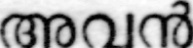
അവന്‍
